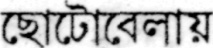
ছোটোবেলায়
